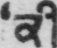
'ਕੀ
